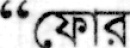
“ফোর
